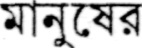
মানুষের
